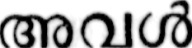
അവള്‍
